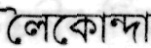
লৈকোন্দা
